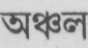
অঞ্চল
